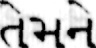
તેમને
